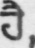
ਹੈ,
